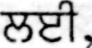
ਲਈ,
